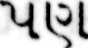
પણ
